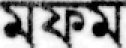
মফম
